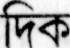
দিক
